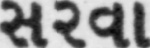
સરવા
